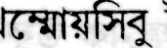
থম্মোয়সিবু
